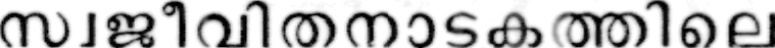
സ്വജീവിതനാടകത്തിലെ
